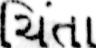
ચિંતા
